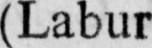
(Labur
